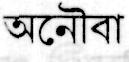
অনৌবা
